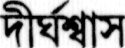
দীর্ঘশ্বাস
